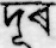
দূৰ
